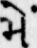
મેં
